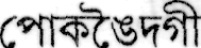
পোকঙৈদগী
